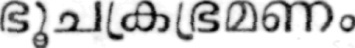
ഭൂചക്രഭ്രമണം
